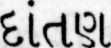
દાંતણ
